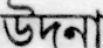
উদনা
